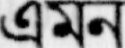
এমন
